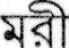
মরী
